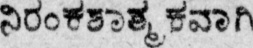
ನಿರಂಕಶಾತ್ಮಕವಾಗಿ
